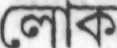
লোক
